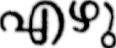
എഴു
